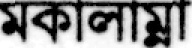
মকালাম্না
